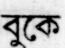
বুকে
